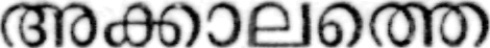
അക്കാലത്തെ
